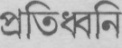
প্রতিধ্বনি
